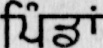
ਪਿੰਡਾਂ
